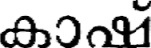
കാഷ്
